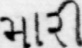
મારી
